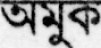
অমুক
